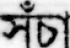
সঁচা
